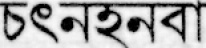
চৎনহনবা
